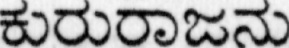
ಕುರುರಾಜನು
